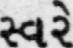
સ્વરે
